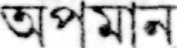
অপমান
